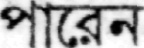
পারেন
